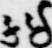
કઈ
